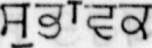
ਸੁਭਾਵਕ
